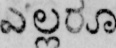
ಎಲ್ಲರೂ
